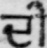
ਦੀ
